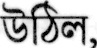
উঠিল,
